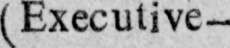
(Executive-
